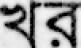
খর
